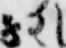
કરી
